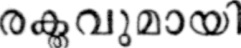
രക്തവുമായി
